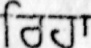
ਰਿਹਾ
